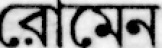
রোমেন
